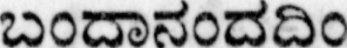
ಬಂದಾನಂದದಿಂ
